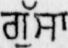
ਗੁੱਸਾ
